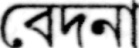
বেদনা
